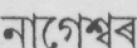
নাগেশ্বৰ
